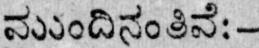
ಮುಂದಿನಂತಿವೆ:-
